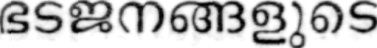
ഭടജനങ്ങളുടെ
